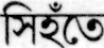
সিহঁতে
